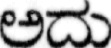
ಅದು
